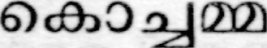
കൊച്ചമ്മ
